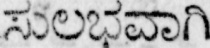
ಸುಲಭವಾಗಿ
